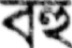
বহু
